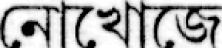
নোখোজে
